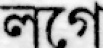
লগে
